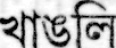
খাঙলি
